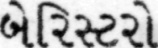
બેરિસ્ટરો
